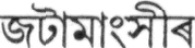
জটামাংসীৰ
